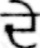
ਦੇ
